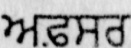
ਅਫ਼ਸਰ
